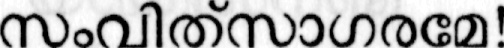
സംവിത്സാഗരമേ!
